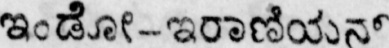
ಇಂಡೋ-ಇರಾಣಿಯನ್
